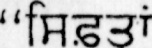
''ਸਿਫ਼ਤਾਂ
